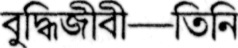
বুদ্ধিজীবী-তিনি
